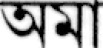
অমা
